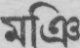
মঞি
